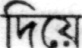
দিয়ে
